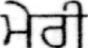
ਮੇਰੀ
